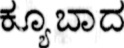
ಕ್ಯೂಬಾದ
